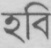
হবি
